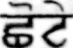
ਛੋਟੇ
